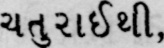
ચતુરાઈથી,
